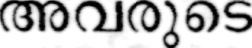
അവരുടെ
